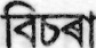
বিচৰা
